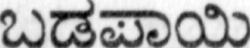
ಬಡಪಾಯಿ
